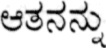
ಆತನನ್ನು
